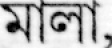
মালা,
